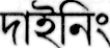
দাইনিং
